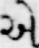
એ
